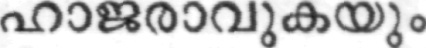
ഹാജരാവുകയും
